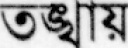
তঙ্খায়
